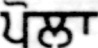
ਪੋਲਾ
